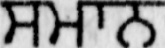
ਸਮਾਨ
